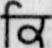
ਕਿ
